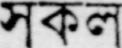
সকল
